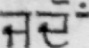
ਜਦੋਂ
